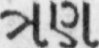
ત્રણ
